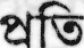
প্ৰতি
